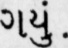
ગયું.
